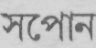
সপোন
